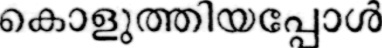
കൊളുത്തിയപ്പോള്‍
